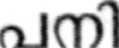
പനി
